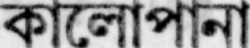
কালোপানা
